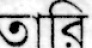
তারি
